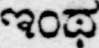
ಇಂಥ
